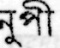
নুপী
